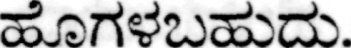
ಹೊಗಳಬಹುದು.
